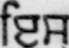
ਇਸ
